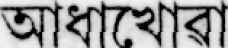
আধাখোৱা
